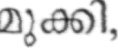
മുക്കി,
